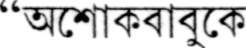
“অশোকবাবুকে
